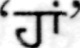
'ਹਾਂ'
